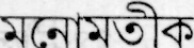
মনোমতীক
